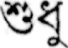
শুধু
